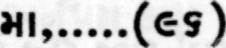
મા....(૯૬)
